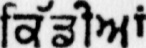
ਕਿੱਡੀਆਂ
